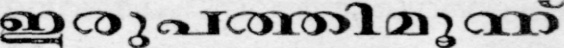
ഇരുപത്തിമൂന്ന്
